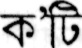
ক’টি
